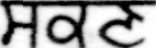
ਸਕਣ
